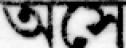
অসে
